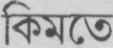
কিমতে
